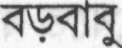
বড়বাবু
